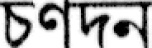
চণদন
